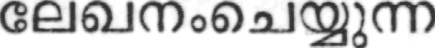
ലേഖനംചെയ്യുന്ന
